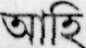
আহি
